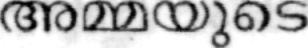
അമ്മയുടെ
